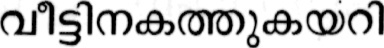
വീട്ടിനകത്തുകയറി
